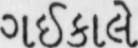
ગઈકાલે
